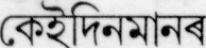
কেইদিনমানৰ
